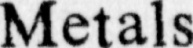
Metals
